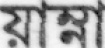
য়াম্না
